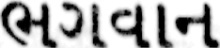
ભગવાન
